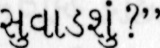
સુવાડશું?"
